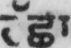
ਹੱਛਾ
